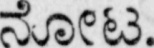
ನೋಟ.
